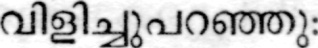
വിളിച്ചുപറഞ്ഞു:
